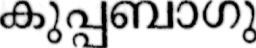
കുപ്പബാഗു
